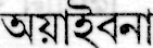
অয়াইবনা
